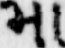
મા
